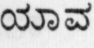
ಯಾವ
